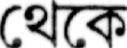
থেকে
